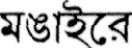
মঙাইরে
